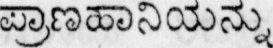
ಪ್ರಾಣಹಾನಿಯನ್ನು
